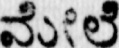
ಮೇಲೆ
